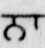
ਨਾ
